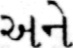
અને
